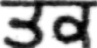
ਤਕ
